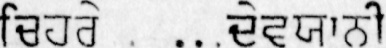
ਚਿਹਰੇ..........ਦੇਵਯਾਨੀ
